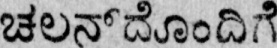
ಚಲನ್‌ದೊಂದಿಗೆ
